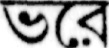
ভরে
